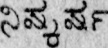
ನಿಷ್ಕರ್ಷ
